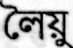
লৈয়ু
